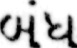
બંધ
